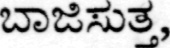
ಬಾಜಿಸುತ್ತ,
